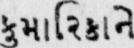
કુમારિકાને
